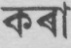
কৰা
